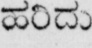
ಹರಿದು
